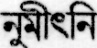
নুমীৎনি
